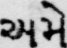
અમે
